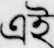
এই
